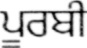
ਪੂਰਬੀ
